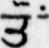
ਤੋਂ
